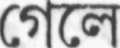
গেলে
